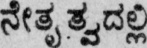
ನೇತೃತ್ವದಲ್ಲಿ
